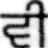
ਵੀ
